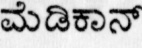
ಮೆಡಿಕಾನ್
